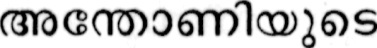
അന്തോണിയുടെ
